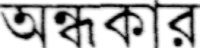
অন্ধকার
